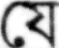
যে
